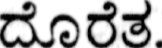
ದೊರೆತ.
